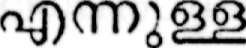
എന്നുള്ള
